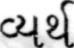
વ્યર્થ
